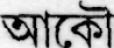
আকৌ
